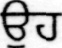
ਉਹ
